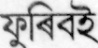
ফুৰিবই
